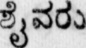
ಶೈವರು
